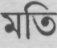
মতি
